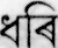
ধৰি
